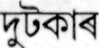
দুটকাৰ
